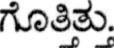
ಗೊತ್ತಿತ್ತು.
